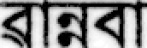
ৱান্নবা
